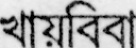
খায়বিবা
